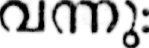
വന്നു:
